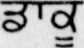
ਡਾਕੂ
